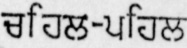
ਚਹਿਲ-ਪਹਿਲ
